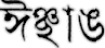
ঈঞ্ছাঙ
